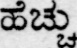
ಹೆಚ್ಚು
